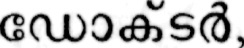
ഡോക്ടര്‍,
